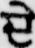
ਦੇ
